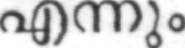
എന്നും
